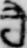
ਹੈ
